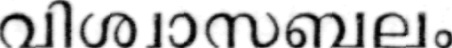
വിശ്വാസബലം
